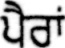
ਪੈਰਾਂ
